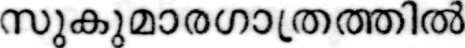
സുകുമാരഗാത്രത്തില്‍
